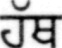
ਹੱਥ
